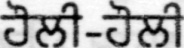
ਹੌਲੀ-ਹੌਲੀ
